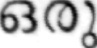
ഒരു
